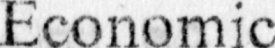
Economic
